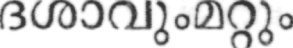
ദശാവുംമറ്റും
